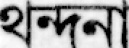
থন্দনা
